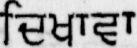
ਦਿਖਾਵਾ
